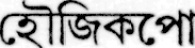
হৌজিকপো
